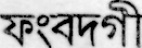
ফংবদগী
